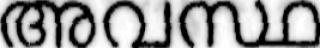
അവസ്ഥ
